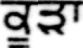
ਕੂੜਾ
